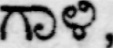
ಗಾಳಿ,
